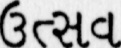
ઉત્સવ
